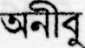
অনীবু
